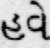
હવે
